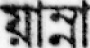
য়ম্না
